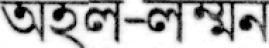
অহল-লম্মন
